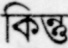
কিন্তু
